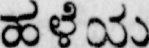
ಹಳೆಯ
